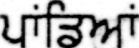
ਪਾਂਡਿਆਂ
